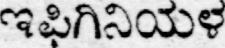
ಇಫಿಗಿನಿಯಳ
